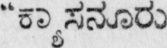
“ಕ್ಯಾಸನೂರು
